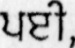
ਪਈ,
